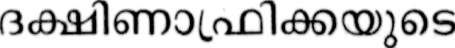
ദക്ഷിണാഫ്രിക്കയുടെ
